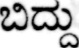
ಬಿದ್ದು
